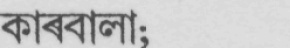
কাৰবালা;
